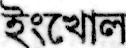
ইংখোল
